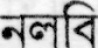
নলবি
